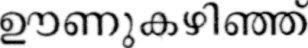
ഊണുകഴിഞ്ഞ്
